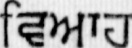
ਵਿਆਹ
